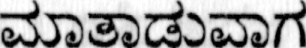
ಮಾತಾಡುವಾಗ
